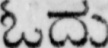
ಓದು
